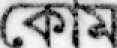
কোম
